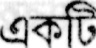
একটি
